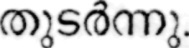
തുടര്‍ന്നു.
